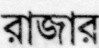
রাজার
